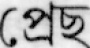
প্রেছ
